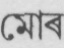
মোৰ
